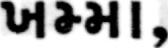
ખમ્મા,
